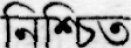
নিশ্চিত
